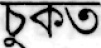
চুকত
